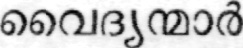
വൈദ്യന്മാര്‍
